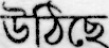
উঠিছে
